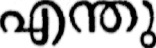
എന്തു
